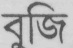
বুজি
